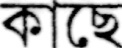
কাছে
